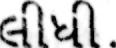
લીધી.
